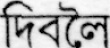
দিবলৈ
